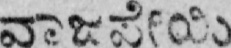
ವಾಜಪೇಯಿ
